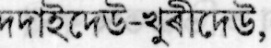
দাইদেউ-খুৰীদেউ,
